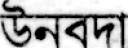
উনবদা
